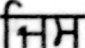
ਜਿਸ
